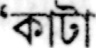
‘কাটা
